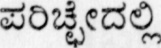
ಪರಿಚ್ಛೇದಲ್ಲಿ
